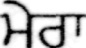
ਮੇਰਾ
